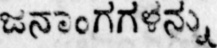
ಜನಾಂಗಗಳನ್ನು
